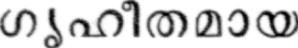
ഗൃഹീതമായ
